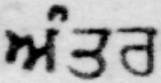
ਅੰਤਰ
